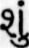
શું
